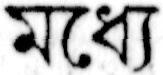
মধ্যে
